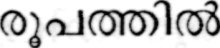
രൂപത്തില്‍
